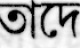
তাদে
